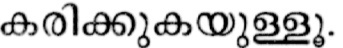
കരിക്കുകയുള്ളൂ.
